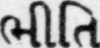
ભીતિ
